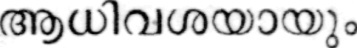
ആധിവശയായും
